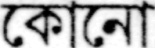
কোনো
